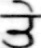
ਤੇ
